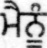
ਮੈਨੂੰ
